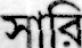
সারি
